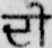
ਦੀ
